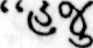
"હજુ
